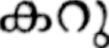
കറു
